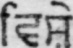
ਵਿਸ਼ੇ
